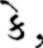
કે,
